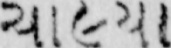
ચાલ્યા
